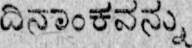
ದಿನಾಂಕವನ್ನು
